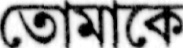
তোমাকে
